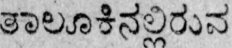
ತಾಲೂಕಿನಲ್ಲಿರುವ
